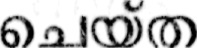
ചെയ്ത
